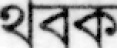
থবক
